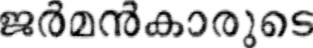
ജര്‍മന്‍കാരുടെ
